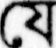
যে
